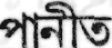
পানীত
